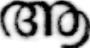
ആ
